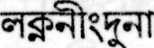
লক্ননীংদুনা
